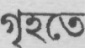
গৃহতে
